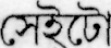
সেইটো
